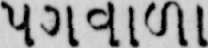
પગવાળા
